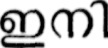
ഇനി
